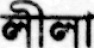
লীলা
